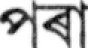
পৰা
